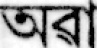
অৱা
